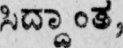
ಸಿದ್ದಾಂತ,
